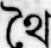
থৈ
